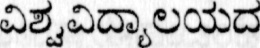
ವಿಶ್ವವಿದ್ಯಾಲಯದ
